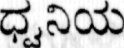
ಧ್ವನಿಯ
